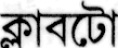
ক্লাবটো
